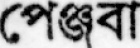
পেঞ্জবা
